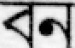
বন
